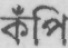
কঁপি
